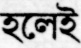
হলেই
